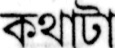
কথাটা
